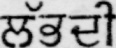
ਲੱਭਦੀ
